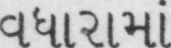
વધારામાં
